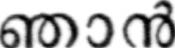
ഞാന്‍
